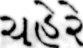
ચહેરે
